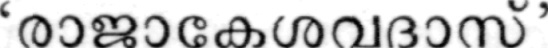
'രാജാകേശവദാസ്'
